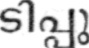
ടിപ്പു
